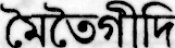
মৈতৈগীদি
